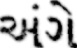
અંગે
